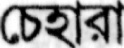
চেহারা
